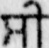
ਸੀ
